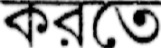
করতে
